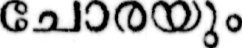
ചോരയും
